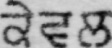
ਕੇਵਲ
